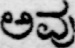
ಅವು
